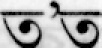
ত'ত
